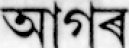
আগৰ
